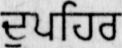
ਦੁਪਹਿਰ
